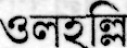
ওলহল্লি
